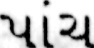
પાંચ
